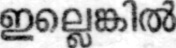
ഇല്ലെങ്കില്‍
